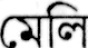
মেলি
